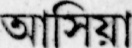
আসিয়া
